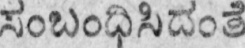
ಸಂಬಂಧಿಸಿದಂತೆ
